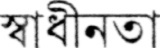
স্বাধীনতা
